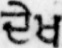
ਦੇਖ
